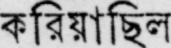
করিয়াছিল
